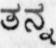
ತನ್ನ
